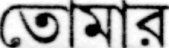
তোমার
